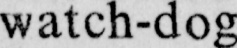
watch-dog
